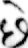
છે
